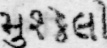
મુશ્કેલી
